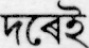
দৰেই
